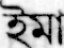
ইমা
